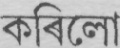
কৰিলো
